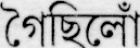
গৈছিলোঁ
